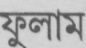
ফুলাম
